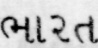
ભારત
